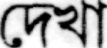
দেখা
